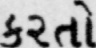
કરતો
